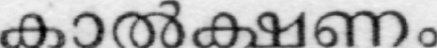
കാല്‍ക്ഷണം
